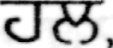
ਹਲ,
